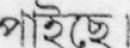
পাইছে
